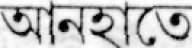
আনহাতে
